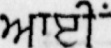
ਆਈਂ
